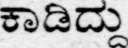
ಕಾಡಿದ್ದು
